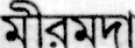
মীরমদা
